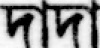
দাদা
